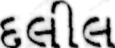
દલીલ
